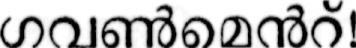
ഗവണ്‍മെന്റ്!
